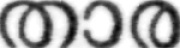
താര
